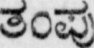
ತಂಪು
